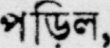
পড়িল,
